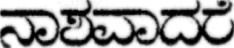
ನಾಶವಾದರೆ
